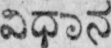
ವಿಧಾನ
